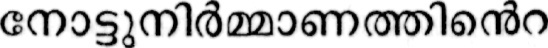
നോട്ടുനിര്‍മ്മാണത്തിന്റെ
